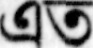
এত
